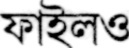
ফাইলও
